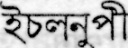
ইচলনুপী
